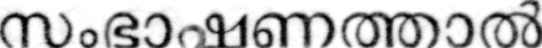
സംഭാഷണത്താല്‍
